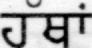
ਹੱਥਾਂ
